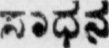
ಸಾಧನ
